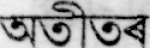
অতীতৰ
